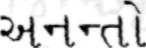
અનન્તો
